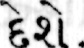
દેશે.
